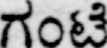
ಗಂಟೆ
